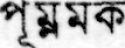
পূম্নমক
